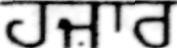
ਹਜ਼ਾਰ
